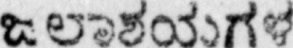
ಜಲಾಶಯಗಳ
